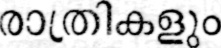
രാത്രികളും
